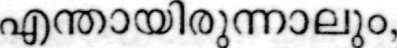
എന്തായിരുന്നാലും,
